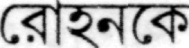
রোহনকে
